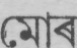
মোৰ
